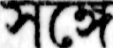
সঙ্গে
